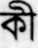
কী
